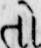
તો
